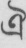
ঐ
